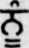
ਨੂੰ
